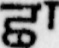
ਛਾ
